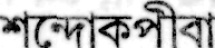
শন্দোকপীবা
